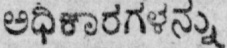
ಅಧಿಕಾರಗಳನ್ನು
